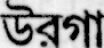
উরগা
